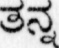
ತನ್ನ
